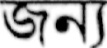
জন্য
